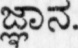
ಜ್ಞಾನ.
